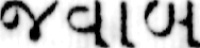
જવાબ
